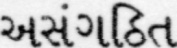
અસંગઠિત
